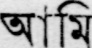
আমি
